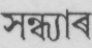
সন্ধ্যাৰ
